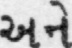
અને
